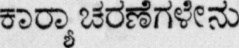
ಕಾರ್ಯಾಚರಣೆಗಳೇನು
